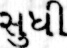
સુધી
